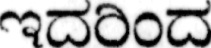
ಇದರಿಂದ
